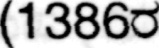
(1386ರ
